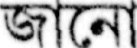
জানো
